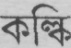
কল্কি
